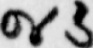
જડ
